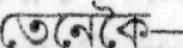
তেনেকৈ-
